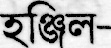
হঞ্জিল-
